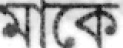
মাকে
